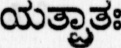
ಯತ್ಪ್ರಾತಃ
